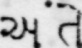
અંતે
